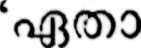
‘ഏതാ
